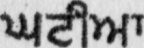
ਘਟੀਆ
